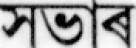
সভাৰ
